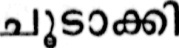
ചൂടാക്കി
